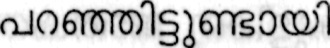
പറഞ്ഞിട്ടുണ്ടായി
